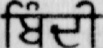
ਬਿੰਦੀ
